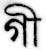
গী
